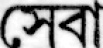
সেবা
